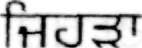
ਜਿਹੜਾ
